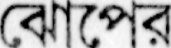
ঝোপের
